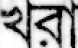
খরা
